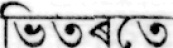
ভিতৰতে
